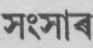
সংসাৰ
